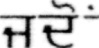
ਜਦੋਂ
